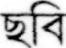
ছবি
